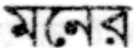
মনের
